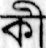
কী
